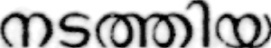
നടത്തിയ
